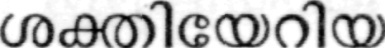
ശക്തിയേറിയ
